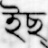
ইছ্
